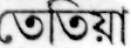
তেতিয়া
